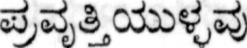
ಪ್ರವೃತ್ತಿಯುಳ್ಳವು
